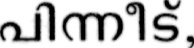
പിന്നീട്,
